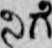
ನಿಗೆ
